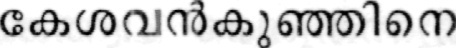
കേശവന്‍കുഞ്ഞിനെ
